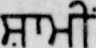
ਸ਼ਾਮੀਂ
